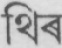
থিৰ
